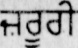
ਜ਼ਰੂਰੀ
